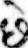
છે
